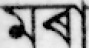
মৰা
